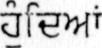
ਹੁੰਦਿਆਂ
